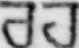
ਰਹ
